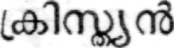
ക്രിസ്ത്യന്‍
